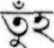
তুঁহ
